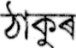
ঠাকুৰ
